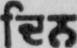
ਦਿਨ
